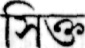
সিক্ত
